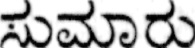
ಸುಮಾರು
